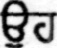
ਉਹ
